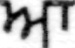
ਆ
